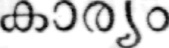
കാര്യം
